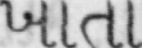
ખાતા
